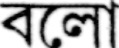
বলো
